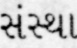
સંસ્થા
